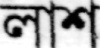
লাশ
